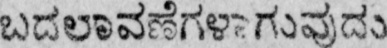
ಬದಲಾವಣೆಗಳಾಗುವುದು
